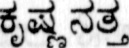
ಕೃಷ್ಣನತ್ತ
